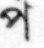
পি
